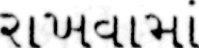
રાખવામાં
